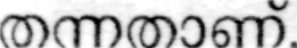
തന്നതാണ്.
